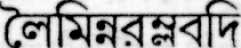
লৈমিন্নরম্লবদি
